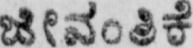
ಜೀವಂತಿಕೆ
